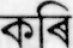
কৰি
